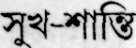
সুখ-শান্তি
